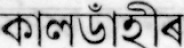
কালডাঁহীৰ
